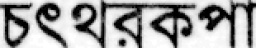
চৎথরকপা
